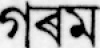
গৰম
